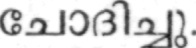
ചോദിച്ചു.
